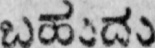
ಬಹುದು
